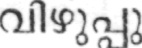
വിഴുപ്പു
